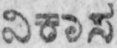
ವಿಕಾಸ
